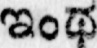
ಇಂಥ
